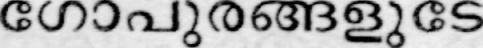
ഗോപുരങ്ങളുടേ
